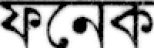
ফনেক
